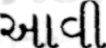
આવી
